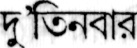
দু'তিনবার
